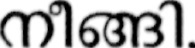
നീങ്ങി.
